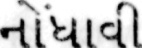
નોંધાવી
